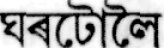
ঘৰটোলৈ
